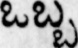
ಒಬ್ಬ
